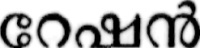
റേഷന്‍
